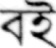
বই
